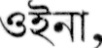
ওইনা,
